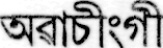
অৱাচীংগী
